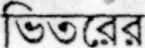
ভিতরের
